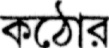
কঠোর
